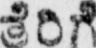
ತೆರಿಗೆ
